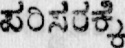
ಪರಿಸರಕ್ಕೆ
